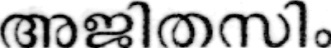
അജിതസിം
